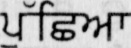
ਪੁੱਛਿਆ
